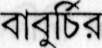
বাবুর্চির
